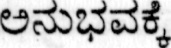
ಅನುಭವಕ್ಕೆ
